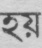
হয়
